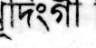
খূদিংগী
